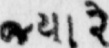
જ્યારે
